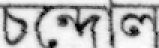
চন্দোল
